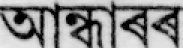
আন্ধাৰৰ
